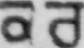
ਕਰ
